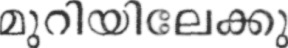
മുറിയിലേക്കു
